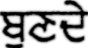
ਬੁਣਦੇ
